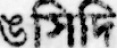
ঙসিদি
